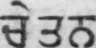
ਚੇਤਨ
